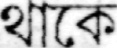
থাকে
